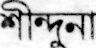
শীন্দুনা
